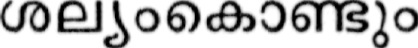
ശല്യംകൊണ്ടും
